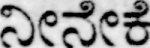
ನೀನೇಕೆ
